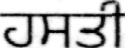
ਹਸਤੀ
